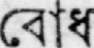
বোধ
